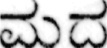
ಮದ
